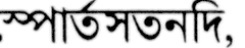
স্পোর্তসতনদি,
